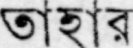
তাহার
